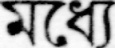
মধ্যে
